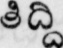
ತಿದ್ದಿ
